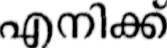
എനിക്ക്
